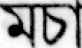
মচা
